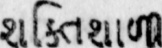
શક્તિશાળી
